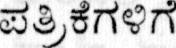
ಪತ್ರಿಕೆಗಳಿಗೆ
